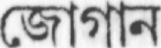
জোগান
